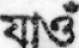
যাওঁ
